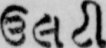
ઉલટી
